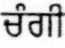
ਚੰਗੀ
